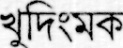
খুদিংমক
